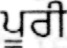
ਪੂਰੀ
